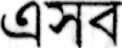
এসব
